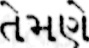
તેમણે
